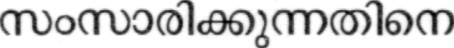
സംസാരിക്കുന്നതിനെ
